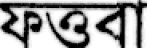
ফত্তবা
